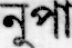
নুপা
